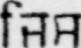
ਜਿਸ
